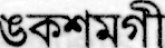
ঙকশমগী
